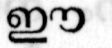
ഈ
